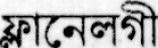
ফ্লানেলগী
